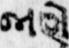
જાણે
